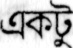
একটু
